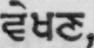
ਵੇਖਣ,
